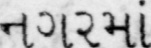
નગરમાં
